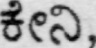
ಕೇನಿ,
